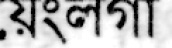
য়েংলগা
